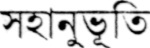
সহানুভূতি
